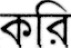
করি
